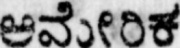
ಅಮೇರಿಕ
